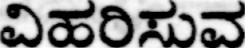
ವಿಹರಿಸುವ
